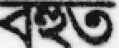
বহুত
